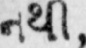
નથી,
